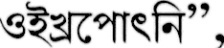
ওইখ্রপোৎনি”,
